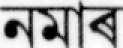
নমাৰ
